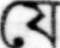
যে
